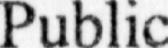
Public
